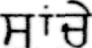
ਸਾਂਚੇ
